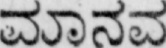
ಮಾನವ
